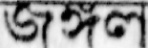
জঙ্গল
